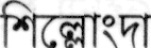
শিল্লোংদা
